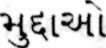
મુદ્દાઓ
